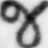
જ
